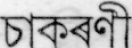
চাকৰণী
